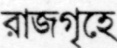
রাজগৃহে
